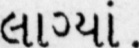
લાગ્યાં.
